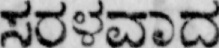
ಸರಳವಾದ
